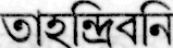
তাহন্দ্রিবনি
